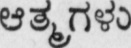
ಆತ್ಮಗಳು
